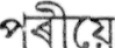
পৰীয়ে
